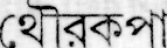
থৌরকপা
